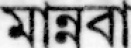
মান্নবা
